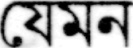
যেমন
